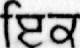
ਇਕ
